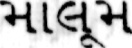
માલૂમ
